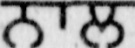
ਨਾਲ
